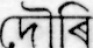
দৌৰি
